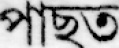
পাছত
